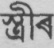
স্ত্রীৰ
